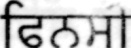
ਫਿਨਸੀ
